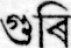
গুৰি
